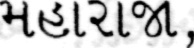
મહારાજા,
